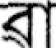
ৱা
